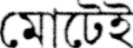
মোটেই
